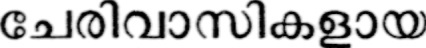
ചേരിവാസികളായ
